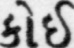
કોઈ
